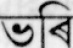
ভৰি
